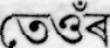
তেওঁৰ
